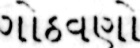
ગોઠવણો
